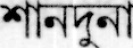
শানদুনা
